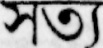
সত্য
